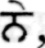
ਨੇ,
